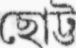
ছোট্ট
